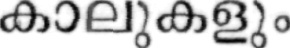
കാലുകളും
